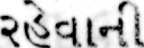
રહેવાની
